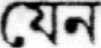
যেন
